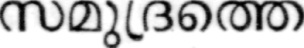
സമുദ്രത്തെ
